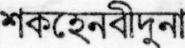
শকহেনবীদুনা
